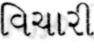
વિચારી
